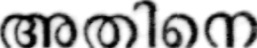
അതിനെ
